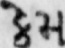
કેમ
